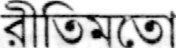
রীতিমতো
